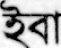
ইবা
